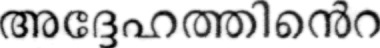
അദ്ദേഹത്തിന്റെ
